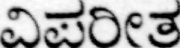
ವಿಪರೀತ
